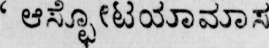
‘ಆಸ್ಫೋಟಯಾಮಾಸ
